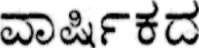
ವಾರ್ಷಿಕದ
